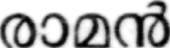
രാമന്‍
